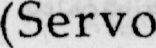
(Servo
